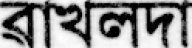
ৱাখলদা
